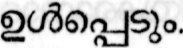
ഉള്‍പ്പെടും.
